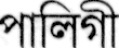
পালিগী
